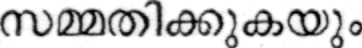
സമ്മതിക്കുകയും
